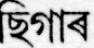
ছিগাৰ
